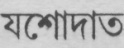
যশোদাত
